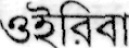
ওইরিবা
